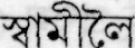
স্বামীলৈ
